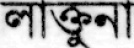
লাক্তুনা
